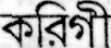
করিগী
